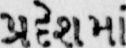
પ્રદેશમાં
